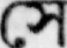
সে
